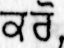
ਕਰੋ,
